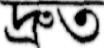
দ্রুত
